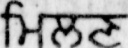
ਮਿਲਣ
